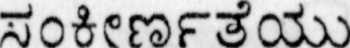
ಸಂಕೀರ್ಣತೆಯು
